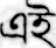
এই
